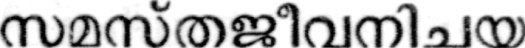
സമസ്തജീവനിചയ
